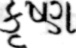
કૃષ્ણ
